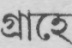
গ্ৰাহে
